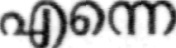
എന്നെ
